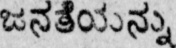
ಜನತೆಯನ್ನು
